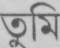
তুমি
